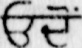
ਓਦੋਂ
